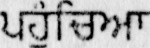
ਪਹੁੰਚਿਆ
